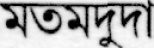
মতমদুদা
